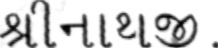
શ્રીનાથજી,
